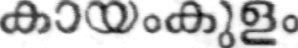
കായംകുളം
